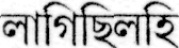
লাগিছিলহি
